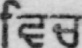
ਵਿਚ
